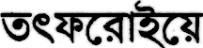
তৎফরোইয়ে
